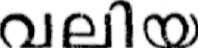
വലിയ
